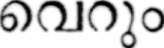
വെറും
